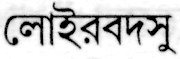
লোইরবদসু
